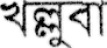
খল্লুবা
